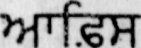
ਆਫ਼ਿਸ
